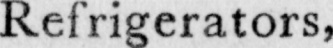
Refrigerators,
